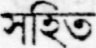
সহিত
